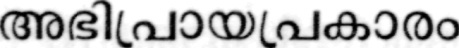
അഭിപ്രായപ്രകാരം
